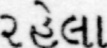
રહેલા
